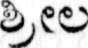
ಶ್ರೀಲ
